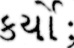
કર્યો;
